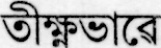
তীক্ষ্ণভাৱে
